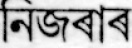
নিজৰাৰ
